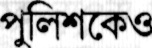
পুলিশকেও
